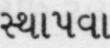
સ્થાપવા
